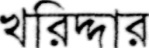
খরিদ্দার
